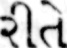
રીતે
